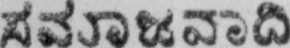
ಸಮಾಜವಾದಿ
